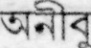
অনীবু
